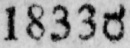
1833ರ
